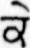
ਕੇ
